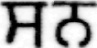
ਸਨ
